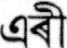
এৰী
